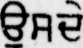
ਉਸਦੇ
